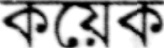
কয়েক
